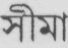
সীমা
